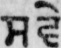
ਸਵੇ
